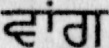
ਵਾਂਗ
